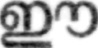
ഈ
